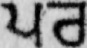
ਪਰ
